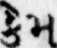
કેમ
